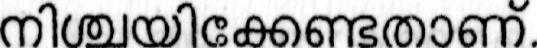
നിശ്ചയിക്കേണ്ടതാണ്.
